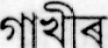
গাখীৰ
